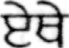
ਏਥੇ
